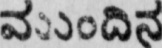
ಮುಂದಿನ
